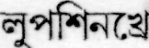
লুপশিনখ্রে
